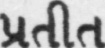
પ્રતીત
